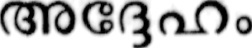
അദ്ദേഹം
